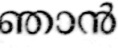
ഞാന്‍
